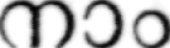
നാം
